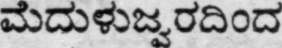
ಮೆದುಳುಜ್ವರದಿಂದ
